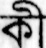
কী
